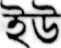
ইউ
